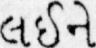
લઈને
